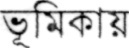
ভূমিকায়
